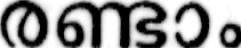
രണ്ടാം
